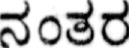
ನಂತರ
